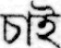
চাই
